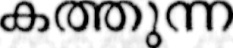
കത്തുന്ന
